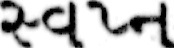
સ્વપ્ન
